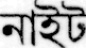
নাইট
